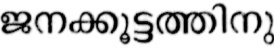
ജനക്കൂട്ടത്തിനു
